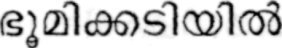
ഭൂമിക്കടിയില്‍
